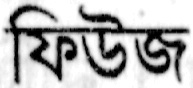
ফিউজ
